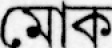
মোক
